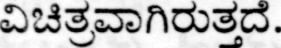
ವಿಚಿತ್ರವಾಗಿರುತ್ತದೆ.
